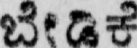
ಬೇಡಿಕೆ
